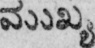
ಮುಖ್ಯ
